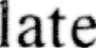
late
